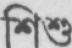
শিশু
